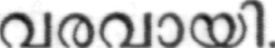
വരവായി.
